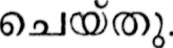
ചെയ്തു.
